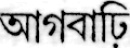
আগবাঢ়ি
